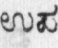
ಉಪ
